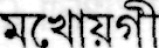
মখোয়গী
